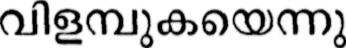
വിളമ്പുകയെന്നു
